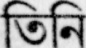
তিনি
